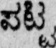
ಪಟ್ಟಿ
